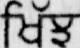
ਖਿੱਝ
